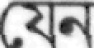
যেন
